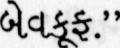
બેવકૂફ."
